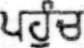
ਪਹੁੰਚ
